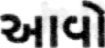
આવો
